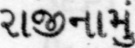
રાજીનામું
